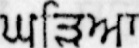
ਘੜਿਆ
